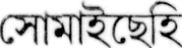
সোমাইছেহি
